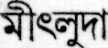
মীৎলুদা
